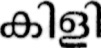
കിളി
